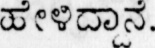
ಹೇಳಿದ್ದಾನೆ.
